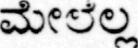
ಮೇಲೆಲ್ಲ
